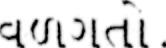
વળગતો.
